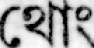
থোং
